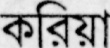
করিয়া
